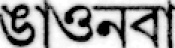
ঙাওনবা
